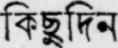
কিছুদিন
